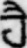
ਹੈ
